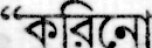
“করিনো
